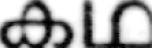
കഥ
